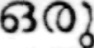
ഒരു
